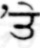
'ਤੇ
